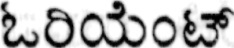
ಓರಿಯೆಂಟ್
